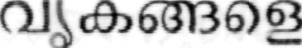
വൃകങ്ങളെ
